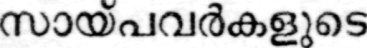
സായ്പവര്‍കളുടെ
